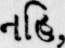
નહિ,
